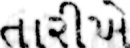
તારીખે
